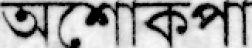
অশোকপা
